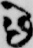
છે
